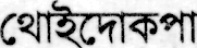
থোইদোকপা
